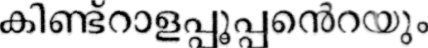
കിണ്ട്റാളപ്പൂപ്പന്റെയും
